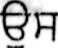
ਉਸ
